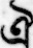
ঐ
